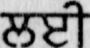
ਲਈ
